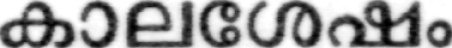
കാലശേഷം
